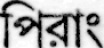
পিরাং
